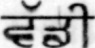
ਵੱਡੀ
